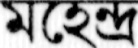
মহেন্দ্র
